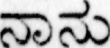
ನಾನು
